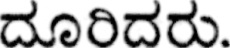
ದೂರಿದರು.
